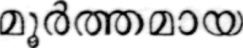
മൂര്‍ത്തമായ
